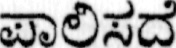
ಪಾಲಿಸದೆ
